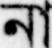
না
